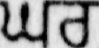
ਘਰ
